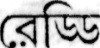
রেড্ডি
